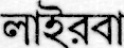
লাইরবা
